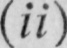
(ii)
